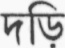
দড়ি
